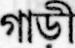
গাড়ী
